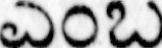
ಎಂಬ
